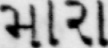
મારા
